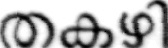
തകഴി
